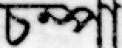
চম্পা
